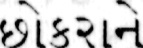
છોકરાને
